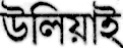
উলিয়াই
